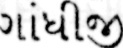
ગાંધીજી
